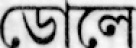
ডোলে
